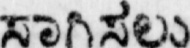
ಸಾಗಿಸಲು
